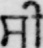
ਸੀ
